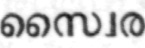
സ്വൈര
